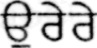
ਉਰੇਰੇ
